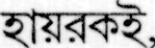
হায়রকই,
